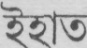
ইহাত
